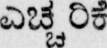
ಎಚ್ಚರಿಕೆ
